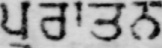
ਪੁਰਾਤਨ
